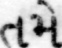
તમે
